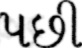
પછી
